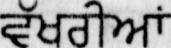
ਵੱਖਰੀਆਂ
